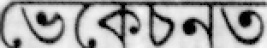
ভেকেচনত
